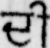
ਦੀ
